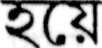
হয়ে
